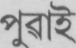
পুৱাই
